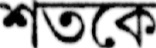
শতকে
